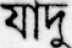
যাদু
